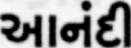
આનંદી
